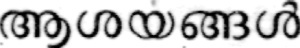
ആശയങ്ങള്‍
